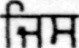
ਜਿਸ
